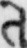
તે
